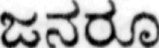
ಜನರೂ
